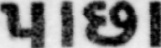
પાછા
